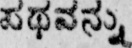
ಪಥವನ್ನು
